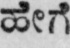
ಹೇಗೆ
